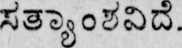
ಸತ್ಯಾಂಶವಿದೆ.
